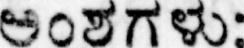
ಅಂಶಗಳು:
